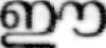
ഈ
